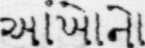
આંખોનો
